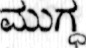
ಮುಗ್ಧ
